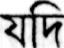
যদি
